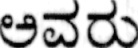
ಅವರು
